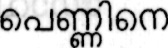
പെണ്ണിനെ
